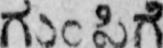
ಗುಂಪಿಗೆ
